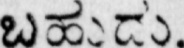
ಬಹುದು.
